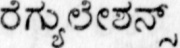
ರೆಗ್ಯುಲೇಶನ್ಸ್
